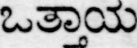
ಒತ್ತಾಯ
